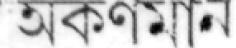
অকণমান
